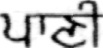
ਪਾਣੀ
